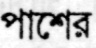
পাশের
